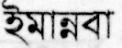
ইমান্নবা
